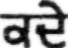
ਕਦੇ
